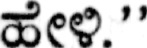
ಹೇಳಿ."
